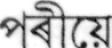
পৰীয়ে
